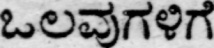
ಒಲವುಗಳಿಗೆ
